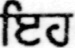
ਇਹ
